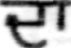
ਦਾ
